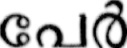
പേര്‍
